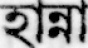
হান্না
